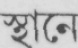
স্থানে
